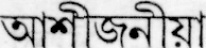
আশীজনীয়া
